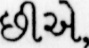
છીએ,
